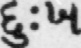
દુઃખ
